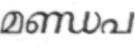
മണ്ഡപ
